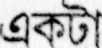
একটা
